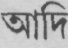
আদি
